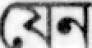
যেন
